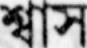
শ্বাস
